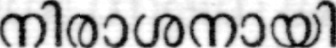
നിരാശനായി
